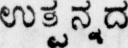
ಉತ್ಪನ್ನದ
